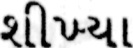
શીખ્યા
